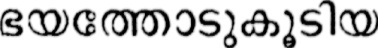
ഭയത്തോടുകൂടിയ
